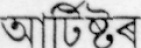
আৰ্টিষ্টৰ
